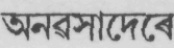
অনৱসাদেৰে
